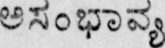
ಅಸಂಭಾವ್ಯ
